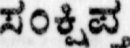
ಸಂಕ್ಷಿಪ್ತ
